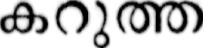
കറുത്ത
